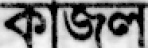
কাজল
